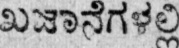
ಖಜಾನೆಗಳಲ್ಲಿ
